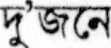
দু'জনে
